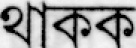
থাকক
